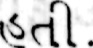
હતી.
